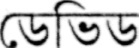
ডেভিড
